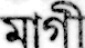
মাগী
